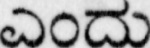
ಎಂದು
